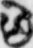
છે
